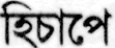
হিচাপে
